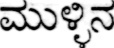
ಮುಳ್ಳಿನ
